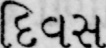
દિવસ
